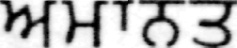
ਅਮਾਨਤ
